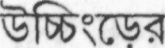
উচ্চিংড়ের
